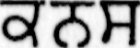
ਕਨਸ
